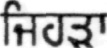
ਜਿਹੜਾ
